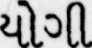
યોગી
